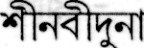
শীনবীদুনা
